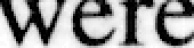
were
